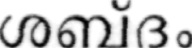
ശബ്ദം
